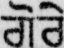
ਗੋਰੇ
